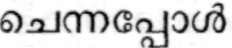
ചെന്നപ്പോള്‍
